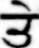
ਤੇ
